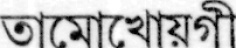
তামোখোয়গী
